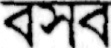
বসব
